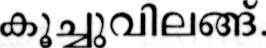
കൂച്ചുവിലങ്ങ്.
